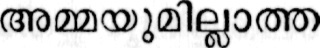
അമ്മയുമില്ലാത്ത
